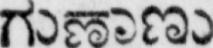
ಗುಣಾಣು
